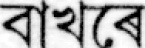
বাখৰে
